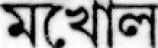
মখোল
